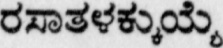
ರಸಾತಳಕ್ಕುಯ್ಯೆ
